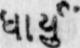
ધાર્યું
